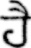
ਹੈ
